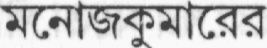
মনোজকুমারের
